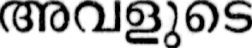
അവളുടെ
